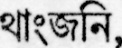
থাংজনি,
